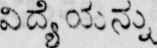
ವಿದ್ಯೆಯನ್ನು
